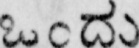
ಒಂದು
